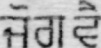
ਜੋਗਵੈ
